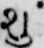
શું
